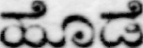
ಹೊಡೆ
